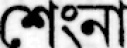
শেংনা
